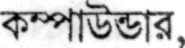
কম্পাউন্ডার,
